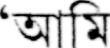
‘আমি
